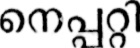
നെപ്പറ്റി
